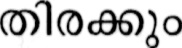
തിരക്കും
